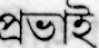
প্রভাই
